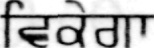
ਵਿਕੇਗਾ
